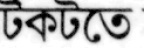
টিকটতে
